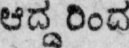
ಆದ್ದರಿಂದ
